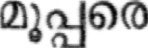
മൂപ്പരെ
